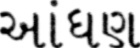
આંધણ
